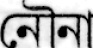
নৌনা
